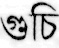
গুচি
